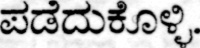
ಪಡೆದುಕೊಳ್ಳಿ.
